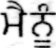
ਮੈਨੂੰ
